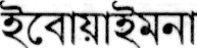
ইবোয়াইমনা
